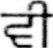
ਵੀ
